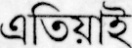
এতিয়াই
